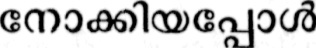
നോക്കിയപ്പോള്‍
